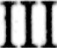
III
